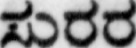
ಸುರರ
